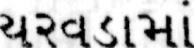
યરવડામાં
